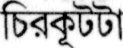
চিরকূটটা
